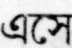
এসে
